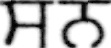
ਸਨ
